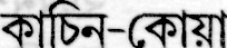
কাচিন-কোকয়া
